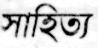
সাহিত্য
